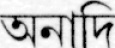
অনাদি
